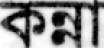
কন্না
